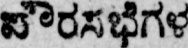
ಪೌರಸಭೆಗಳ
